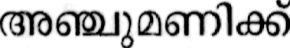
അഞ്ചുമണിക്ക്
